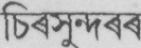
চিৰসুন্দৰৰ
